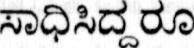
ಸಾಧಿಸಿದ್ದರೂ
